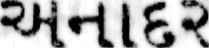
અનાદર
